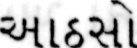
આઠસો
